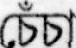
চেঁচা
